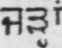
ਜੜ੍ਹਾਂ
